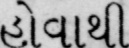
હોવાથી
